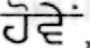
ਹੋਵੇਂ,
